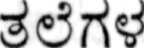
ತಲೆಗಳ
